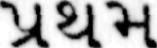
પ્રથમ
